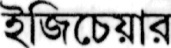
ইজিচেয়ার
